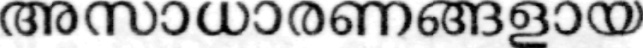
അസാധാരണങ്ങളായ
